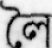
লৈ
